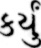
કર્યું
